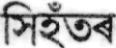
সিহঁতৰ
